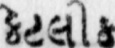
કેટલીક
